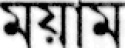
ময়াম
